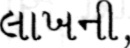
લાખની,
